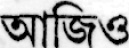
আজিও
